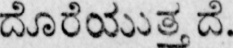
ದೊರೆಯುತ್ತದೆ.
